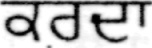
ਕਰਦਾ
